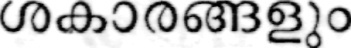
ശകാരങ്ങളും
